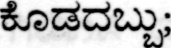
ಕೊಡದಬ್ಬು;
